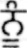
ਨੂੰ
